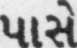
પાસે
